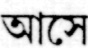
আসে
